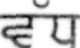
ਵੱਧ
